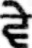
ਵੇ
